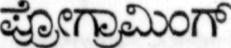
ಪ್ರೋಗ್ರಾಮಿಂಗ್
